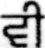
ਵੀ
